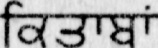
ਕਿਤਾਬਾਂ
